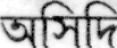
অসিদি
